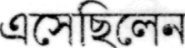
এসেছিলেন
